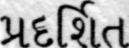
પ્રદર્શિત
